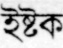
ইষ্টক
